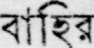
বাহির
